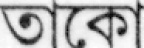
তাকো
